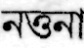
নত্তনা
